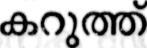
കറുത്ത്
